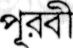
পূরবী
